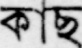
কাছ
